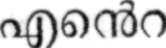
എന്റെ
